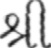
શ્રી
